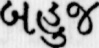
બહુજ
